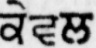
ਕੇਵਲ
